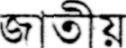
জাতীয়
